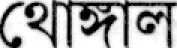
থোঙ্গাল
